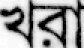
খরা
